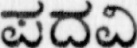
ಪದವಿ
